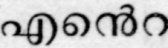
എന്റെ
